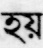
হয়
